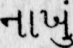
નાખું
